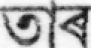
তাৰ
